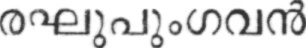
രഘുപുംഗവന്‍
